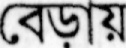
বেড়ায়
